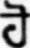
ਹੋ
